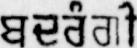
ਬਦਰੰਗੀ
